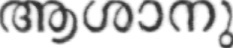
ആശാനു
